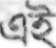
এই
